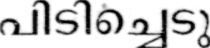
പിടിച്ചെടു
